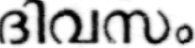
ദിവസം
